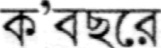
ক’বছরে
